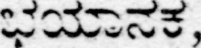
ಭಯಾನಕ,
